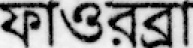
ফাওরব্রা
